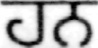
ਹਨ
